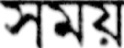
সময়
